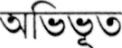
অভিভূত
